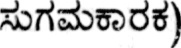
ಸುಗಮಕಾರಕ)
